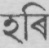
হৰি
